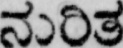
ನುರಿತ
